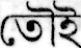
তৌই
